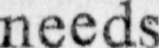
needs
